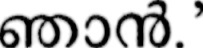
ഞാന്‍.’
